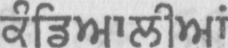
ਕੰਡਿਆਲੀਆਂ
